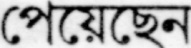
পেয়েছেন
